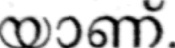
യാണ്.
